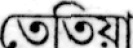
তেতিয়া
